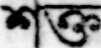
শক্ত
